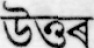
উত্তৰ
